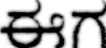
ಈಗ
